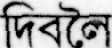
দিবলৈ
